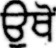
ਉਥੋਂ
